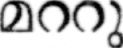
മററു
